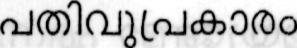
പതിവുപ്രകാരം
